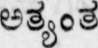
ಅತ್ಯಂತ
